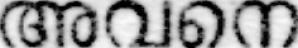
അവനെ
